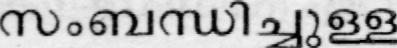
സംബന്ധിച്ചുള്ള
